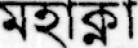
মহাক্না
